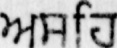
ਅਸਹਿ
